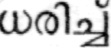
ധരിച്ച്
